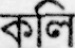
কলি
